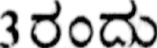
3ರಂದು
